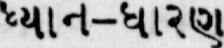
ધ્યાન-ધારણ
